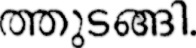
ത്തുടങ്ങി.
